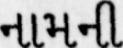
નામની
